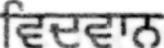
ਵਿਦਵਾਨ
